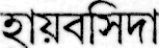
হায়বসিদা
